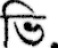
ভি.
